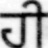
ਹੀ
